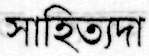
সাহিত্যদা
